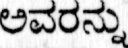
ಅವರನ್ನು
